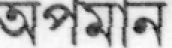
অপমান
